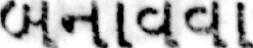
બનાવવા
